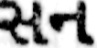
સન
